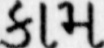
કામ
